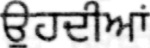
ਉਹਦੀਆਂ
